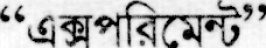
“এক্সপরিমেন্ট”
